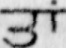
ਤਾਂ
